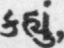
કહ્યું,
